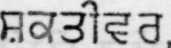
ਸ਼ਕਤੀਵਰ,
